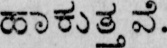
ಹಾಕುತ್ತವೆ.
